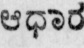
ಆಧಾರ
